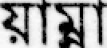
য়াম্না
